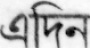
এদিন
